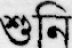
শুনি
